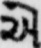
એ
